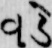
વડે
